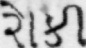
રોકી
